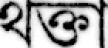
থক্তা
